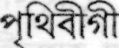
পৃথিবীগী
